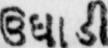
ઉઘાડી
